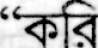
“করি
